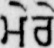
ਮੇਰੇ
